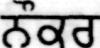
ਨੌਕਰ
